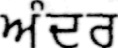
ਅੰਦਰ
